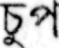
চুপ
